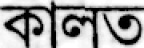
কালত
